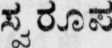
ಸ್ವರೂಪ
